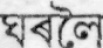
ঘৰলৈ
